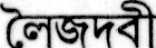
লৈজদবী
